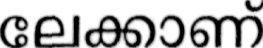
ലേക്കാണ്
